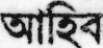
আহিব
